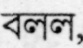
বলল,
